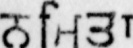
ਨਮਿਤਾ
